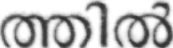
ത്തില്‍
